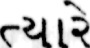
ત્યારે
